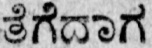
ತೆಗೆದಾಗ
